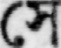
সে
